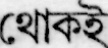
থোকই
